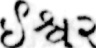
ઈશ્વર
